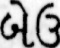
બેઉ
